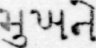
મુખને
